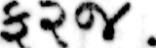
ફરજ.
